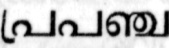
പ്രപഞ്ച
